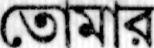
তোমার
